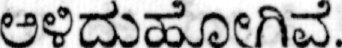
ಅಳಿದುಹೋಗಿವೆ.
